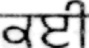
ਕਈ
